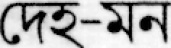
দেহ-মন
